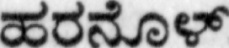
ಹರನೊಳ್
